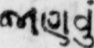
જાણવું
